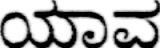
ಯಾವ
